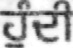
ਹੁੰਦੀ
